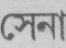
সেনা
